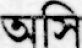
অসি
